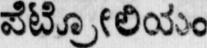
ಪೆಟ್ರೋಲಿಯಂ
